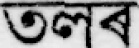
তলৰ
